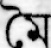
মৈ
